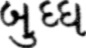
બુધ્ધ
